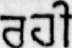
ਰਹੀ
